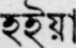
হইয়া
